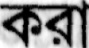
করা
